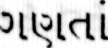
ગણતાં
